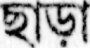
ছাড়া
